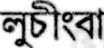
লুচীংবা
